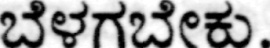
ಬೆಳಗಬೇಕು.
